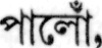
পালোঁ,
